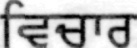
ਵਿਚਾਰ
